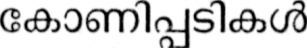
കോണിപ്പടികള്‍
